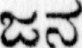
ಜನ
